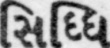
સિધ્ધિ
